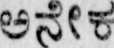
ಅನೇಕ
